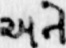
અને
